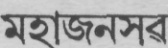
মহাজনসৱ
